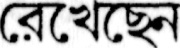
রেখেছেন
